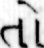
તો
